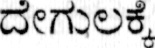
ದೇಗುಲಕ್ಕೆ
